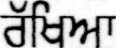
ਰੱਖਿਆ
